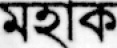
মহাক
